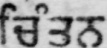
ਚਿੰਤਨ
